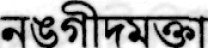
নঙগীদমক্তা
